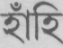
হাঁহি
